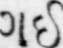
ગઈ
